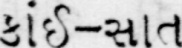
કાંઈ-સાત
